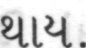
થાય.
